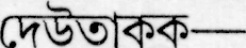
দেউতাকক-
